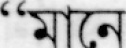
"মানে
